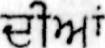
ਦੀਆਂ
